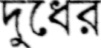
দুধের
